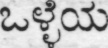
ಒಳ್ಳೆಯ
